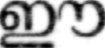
ഈ
